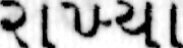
રાખ્યા
